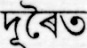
দূৰৈত
